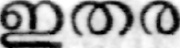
ഇതര
